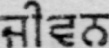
ਜੀਵਨ
